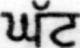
ਘੱਟ
